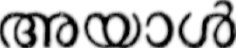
അയാള്‍
